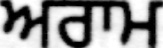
ਅਰਾਮ
